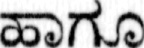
ಹಾಗೂ
